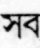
সব
